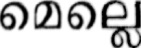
മെല്ലെ
